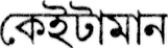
কেইটামান
